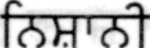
ਨਿਸ਼ਾਨੀ
